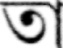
তা
